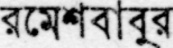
রমেশবাবুর
